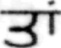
ਤਾਂ
